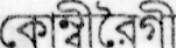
কোম্বীরৈগী
